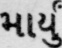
માર્યું
